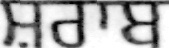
ਸ਼ਰਾਬ
